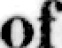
of
